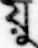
য়ু
